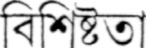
বিশিষ্টতা
